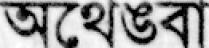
অথেঙবা
